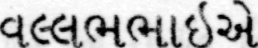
વલ્લભભાઈએ
